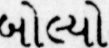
બોલ્યો
